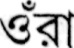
ওঁরা
